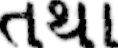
તથા
